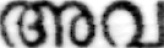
അവ
